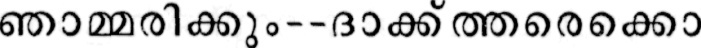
ഞാമ്മരിക്കും--ദാക്ക്ത്തരെക്കൊ
